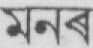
মনৰ
